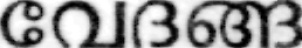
വേദങ്ങ
